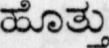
ಹೊತ್ತು
